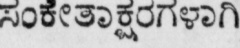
ಸಂಕೇತಾಕ್ಷರಗಳಾಗಿ
